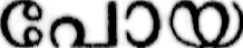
പോയ
